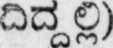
ದಿದ್ದಲ್ಲಿ)
